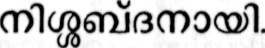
നിശ്ശബ്ദനായി.
